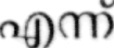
എന്ന്
